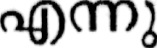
എന്നു
